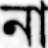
না
